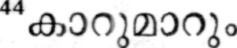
44കാറുമാറും
